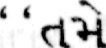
"તમે
